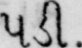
પડી.
